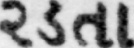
રડતા
